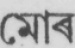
মোৰ
